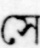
সে
